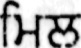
ਮਿਲ
